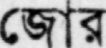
জোর
